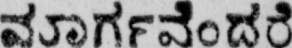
ಮಾರ್ಗವೆಂದರೆ
